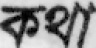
কথা
